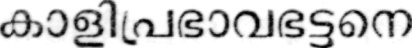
കാളിപ്രഭാവഭട്ടനെ
